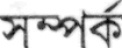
সম্পর্ক
